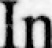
In
